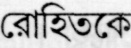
রোহিতকে
